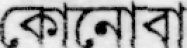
কোনোবা
